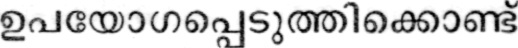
ഉപയോഗപ്പെടുത്തിക്കൊണ്ട്
